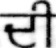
ਦੀ
